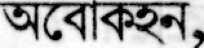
অবোকহন,
